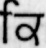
ਕਿ
